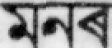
মনৰ
